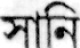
সানি
